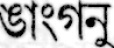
ঙাংগনু
